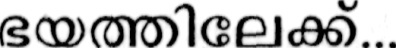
ഭയത്തിലേക്ക്...
